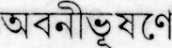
অবনীভূষণে
